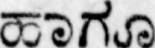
ಹಾಗೂ
